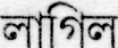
লাগিল
